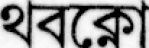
থবক্নো
